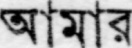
আমার
